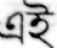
এই
